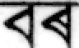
বৰ
